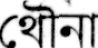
থৌনা
